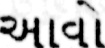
આવો
